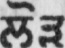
ਲੋੜ
